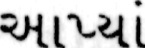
આપ્યાં
